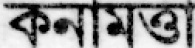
কনামত্তা
